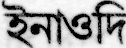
ইনাওদি
